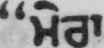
''ਮੇਰਾ
